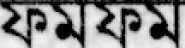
ফমফম
